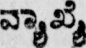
ವ್ಯಾಖ್ಯೆ
